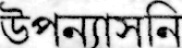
উপন্যাসনি
